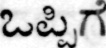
ಒಪ್ಪಿಗೆ
